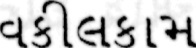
વકીલકામ
